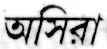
অসিরা
